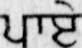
ਪਾਏ
